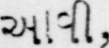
આવી,
